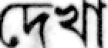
দেখা
